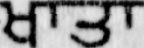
ਖਾਤਾ
